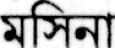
মসিনা
